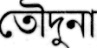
তৌদুনা
